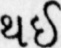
થઈ
